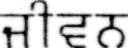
ਜੀਵਨ
